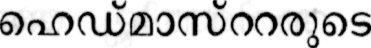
ഹെഡ്മാസ്ററരുടെ
